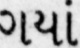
ગયાં
